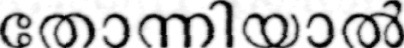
തോന്നിയാല്‍
